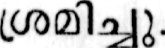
ശ്രമിച്ചു.
